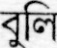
বুলি
